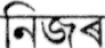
নিজৰ
